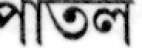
পাতল
